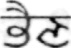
ਭੈਣ
